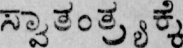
ಸ್ವಾತಂತ್ರ್ಯಕ್ಕೆ
